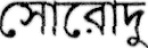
সোরোদু
